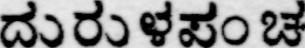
ದುರುಳಪಂಚ
